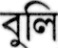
বুলি
